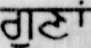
ਗੁਣਾਂ
